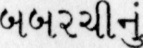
બબરચીનું
